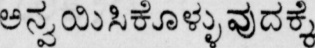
ಅನ್ವಯಿಸಿಕೊಳ್ಳುವುದಕ್ಕೆ
